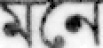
মনে
